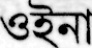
ওইনা
